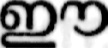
ഈ
